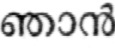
ഞാന്‍
